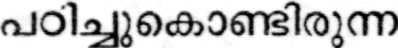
പഠിച്ചുകൊണ്ടിരുന്ന
